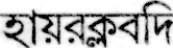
হায়রক্লবদি
